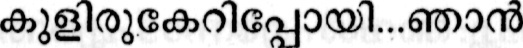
കുളിരുകേറിപ്പോയി...ഞാന്‍
